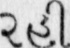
રહી
